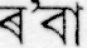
ৰ'বা
